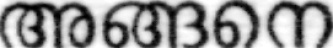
അങ്ങനെ
